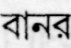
বানর
